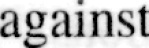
against
